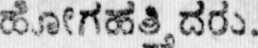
ಹೋಗಹತ್ತಿದರು.
